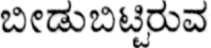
ಬೀಡುಬಿಟ್ಟಿರುವ
